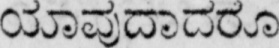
ಯಾವುದಾದರೂ
